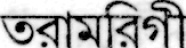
তরামরিগী
